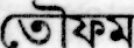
তৌফম
